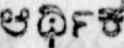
ಆರ್ಥಿಕ
